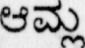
ಆಮ್ಲ
